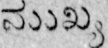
ಮುಖ್ಯ
